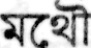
মথৌ
